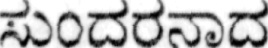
ಸುಂದರನಾದ
